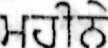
ਮਹੀਨੇ
